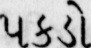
પકડો
